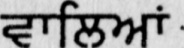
ਵਾਲਿਆਂ
